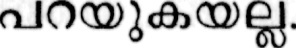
പറയുകയല്ല.
